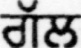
ਗੱਲ
